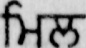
ਮਿਲ
